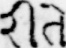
રીતે
